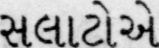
સલાટોએ
